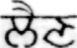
ਲੈਣ
